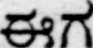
ಈಗ
